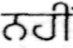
ਨਹੀਂ
